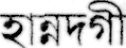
হান্নদগী
